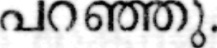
പറഞ്ഞു.
